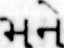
મને
